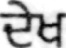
ਦੇਖ
